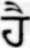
ਹੈ
